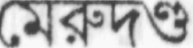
মেরুদ্ণ্ড
